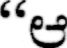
"ಆ
